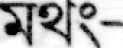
মথং-
